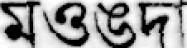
মওঙদা
